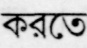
করতে
